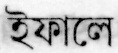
ইফালে
